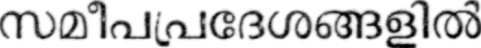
സമീപപ്രദേശങ്ങളില്‍
